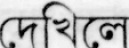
দেখিলে
